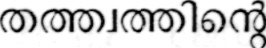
തത്ത്വത്തിന്റെ
